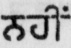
ਨਹੀਂ
